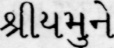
શ્રીયમુને
